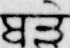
ਬੜੇ
